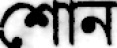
শোন
